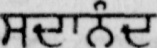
ਸਦਾਨੰਦ
